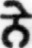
ਨੇ
